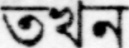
তখন
